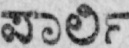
ಪಾರ್ಲಿ
